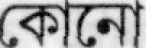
কোনো
